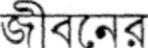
জীবনের
